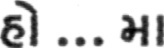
હો...મા
